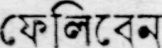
ফেলিবেন
